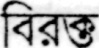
বিরক্ত
